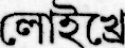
লোইখ্রে
